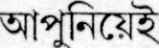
আপুনিয়েই
